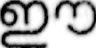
ഈ
